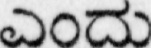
ಎಂದು
